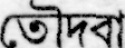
তৌদবা
